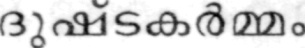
ദുഷ്ടകര്‍മ്മം
